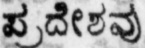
ಪ್ರದೇಶವು
